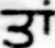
ਤਾਂ
